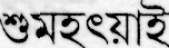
শুমহৎয়াই
